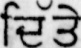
ਦਿੱਤੇ
